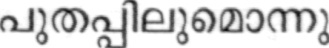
പുതപ്പിലുമൊന്നു
